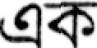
এক
